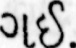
ગઈ.
